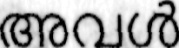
അവള്‍
